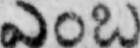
ಎಂಬ
